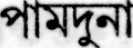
পামদুনা
